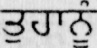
ਤੁਹਾਨੂੰ
